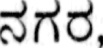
ನಗರ,
